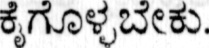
ಕೈಗೊಳ್ಳಬೇಕು.
